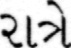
રાત્રે
